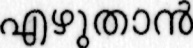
എഴുതാന്‍
